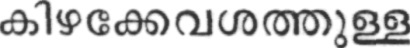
കിഴക്കേവശത്തുള്ള
